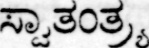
ಸ್ವಾತಂತ್ರ್ಯ
